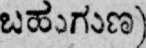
ಬಹುಗುಣ)
